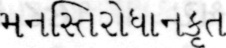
મનસ્તિરોધાનકૃત
